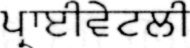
ਪ੍ਰਾਈਵੇਟਲੀ
